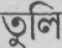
তুলি
